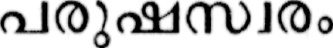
പരുഷസ്വരം
